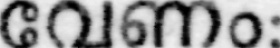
വേണം:
